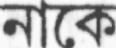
নাকে
